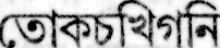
তোকচখিগনি
